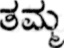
ತಮ್ಮ
